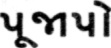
પૂજાપો
